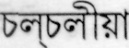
চল্‌চলীয়া
